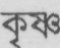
কৃষ্ণ
